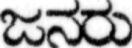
ಜನರು
